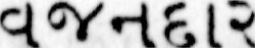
વજનદાર
